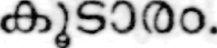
കൂടാരം.
